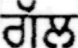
ਗੱਲ
